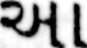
આ
